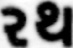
રથ
